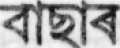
বাছাৰ
